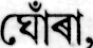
ঘোঁৰা,
